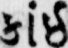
કાંઈ
